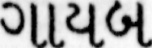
ગાયબ
